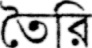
তৈরি
